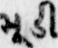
મૂડી
